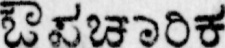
ಔಪಚಾರಿಕ
